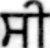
ਸੀ
